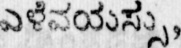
ಎಳೆವಯಸ್ಸು,
